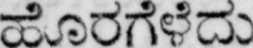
ಹೊರಗೆಳೆದು
